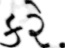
કરે.
